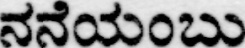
ನನೆಯಂಬು
